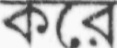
করে
